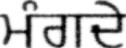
ਮੰਗਦੇ
